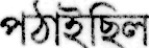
পঠাইছিল
